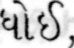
ધોઈ,
